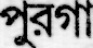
পুরগা
